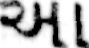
આ
